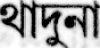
থাদুনা
